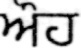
ਔਹ
